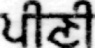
ਪੀਣੀ
